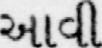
આવી
